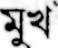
মুখ
